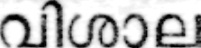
വിശാല
